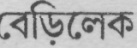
বেড়িলেক
